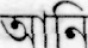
আনি
